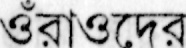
ওঁরাওদের
